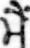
ਮੈਂ
